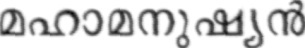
മഹാമനുഷ്യന്‍
